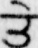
ਤੇ
